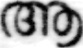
ആ
